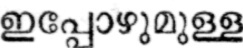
ഇപ്പോഴുമുള്ള
